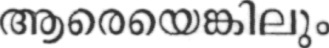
ആരെയെങ്കിലും
